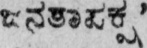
ಜನತಾಪಕ್ಷ’
